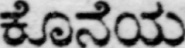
ಕೊನೆಯ
